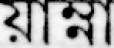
য়াম্না
